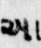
આ
